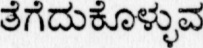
ತೆಗೆದುಕೊಳ್ಳುವ
